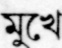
মুখে
